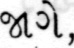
જાગે,
